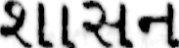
શાસન
